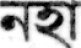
নহা
